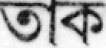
তাক
